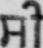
ਸੀ
